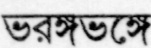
ভরঙ্গভঙ্গে
